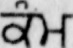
ਕੰਮ
